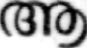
ആ
